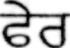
ਫੇਰ
